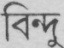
বিন্দু
